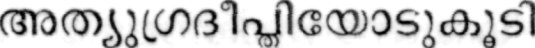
അത്യുഗ്രദീപ്തിയോടുകൂടി
